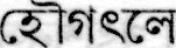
হৌগৎলে
